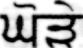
ਘੋੜੇ
